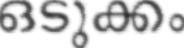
ഒടുക്കം
